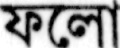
ফলো
